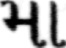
મા
